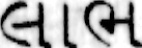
લાભ
